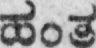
ಹಂತ
